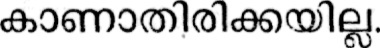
കാണാതിരിക്കയില്ല.
